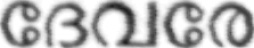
ദേവരേ
